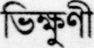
ভিক্ষুণী
